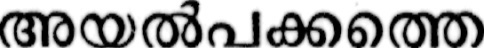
അയല്‍പക്കത്തെ
